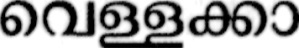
വെള്ളക്കാ
